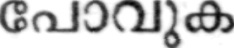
പോവുക
